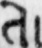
તો
